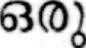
ഒരു
